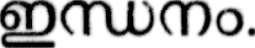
ഇന്ധനം.
